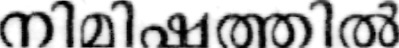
നിമിഷത്തില്‍
